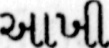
આખી
